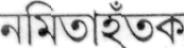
নমিতাহঁতক
